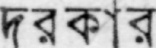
দরকার
